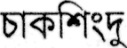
চাকশিংদু
